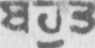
ਬਹੁਤ
